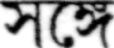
সঙ্গে
